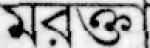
মরক্তা
